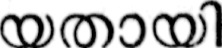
യതായി
